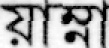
য়াম্না
